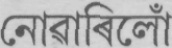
নোৱাৰিলোঁ
